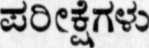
ಪರೀಕ್ಷೆಗಳು
